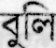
বুলি
